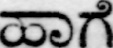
ಹಾಗೆ
